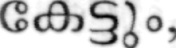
കേട്ടും,
